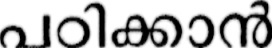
പഠിക്കാന്‍
